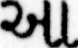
આ
